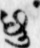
છું
